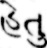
હેતુ
